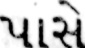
પાસે
